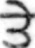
ਤੇ
